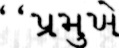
"પ્રમુખે
